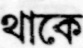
থাকে
